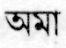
অমা
